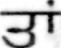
ਤਾਂ
